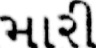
મારી
